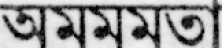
অমমমতা
